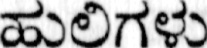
ಹುಲಿಗಳು
